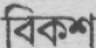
বিকশ
